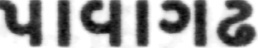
પાવાગઢ
